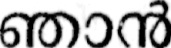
ഞാന്‍
